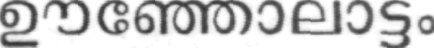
ഊഞ്ഞോലാട്ടം
